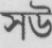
সউ
